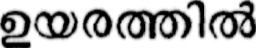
ഉയരത്തില്‍
